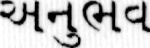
અનુભવ
